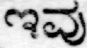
ಇವು
